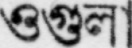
ওগুলা
